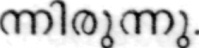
ന്നിരുന്നു.
